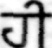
ਹੀ
